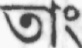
তাং
